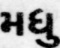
મધુ
